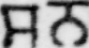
ਸਨ
